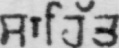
ਸਾਹਿੱਤ
